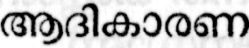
ആദികാരണ
